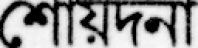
শোয়দনা
